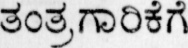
ತಂತ್ರಗಾರಿಕೆಗೆ
